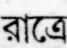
রাত্রে
